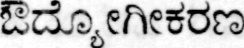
ಔದ್ಯೋಗೀಕರಣ
